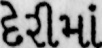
દેરીમાં
